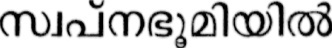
സ്വപ്നഭൂമിയില്‍
